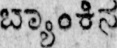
ಬ್ಯಾಂಕಿನ
